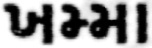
ખમ્મા
